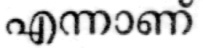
എന്നാണ്
